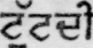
ਟੁੱਟਦੀ
